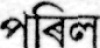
পৰিল
